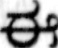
ಈ
